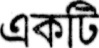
একটি
